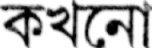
কখনো
